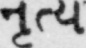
નૃત્ય
